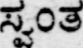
ಸ್ವಂತ
